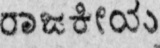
ರಾಜಕೀಯ
